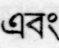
এবং
